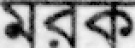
মরক
